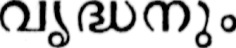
വൃദ്ധനും
